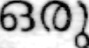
ഒരു
